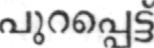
പുറപ്പെട്ട്
